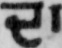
ਦਾ
